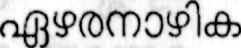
ഏഴരനാഴിക
